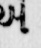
એ
